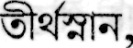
তীর্থস্নান,
